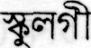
স্কুলগী
